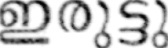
ഇരുട്ടു
